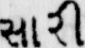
સારી
